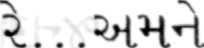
રે...અમને
